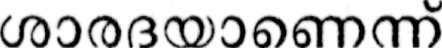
ശാരദയാണെന്ന്
